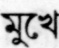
মুখে
